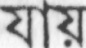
যায়
